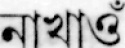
নাখাওঁ
